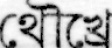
থৌখ্রে
